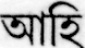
আহি
